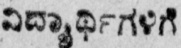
ವಿದ್ಯಾರ್ಥಿಗಳಿಗೆ
